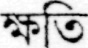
ক্ষতি
